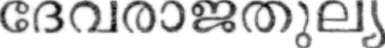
ദേവരാജതുല്യ
